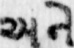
અને
